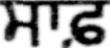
ਸਾਫ਼
